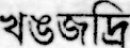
খঙজদ্রি
